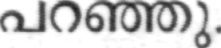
പറഞ്ഞു.
